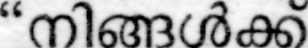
“നിങ്ങള്‍ക്ക്
